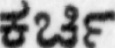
ಕರ್ಚಿ
